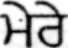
ਮੇਰੇ
